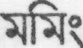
মমিং
